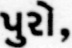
પુરો,
